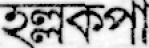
হল্লকপা
